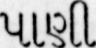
પાણી
